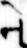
ને
